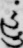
હું
